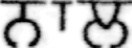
ਨਾਲ
